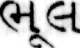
ભૂલ
